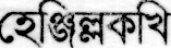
হেঞ্জল্লকখি
